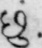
છું.
